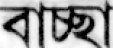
বাচ্ছা
